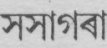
সসাগৰা
